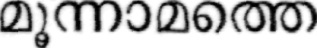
മൂന്നാമത്തെ
